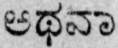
ಅಥವಾ
